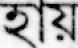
হায়
